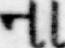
ના
